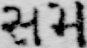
સમ
